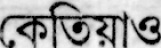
কেতিয়াও
